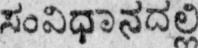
ಸಂವಿಧಾನದಲ್ಲಿ
